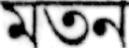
মতন
